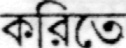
করিতে
